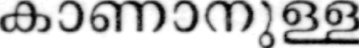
കാണാനുള്ള
